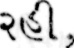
રહી,
